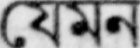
যেমন
